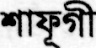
শাফূগী
